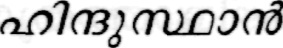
ഹിന്ദുസ്ഥാന്‍
